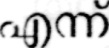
എന്ന്
